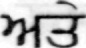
ਅਤੇ
